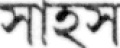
সাহস
